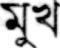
মুখ
